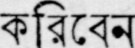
করিবেন
